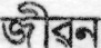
জীৱন
